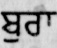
ਬੁਰਾ
